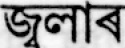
জ্বলাৰ
